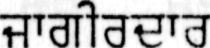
ਜਾਗੀਰਦਾਰ
